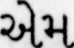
એમ
